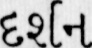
દર્શન
